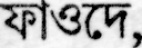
ফাওদে,
